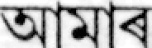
আমাৰ
